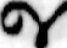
જ
